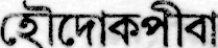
হৌদোকপীবা
